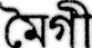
মৈগী
